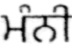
ਮੰਨੀ
